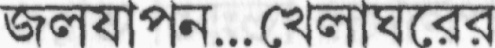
জলযাপন...খেলাঘরের
